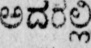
ಅದರಲ್ಲಿ
